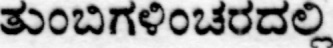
ತುಂಬಿಗಳಿಂಚರದಲ್ಲಿ
